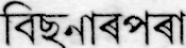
বিছনাৰপৰা
